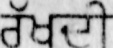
ਰੱਖਦੀ
